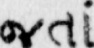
જતાં
